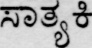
ಸಾತ್ಯಕಿ
